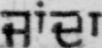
ਜਾਂਦਾ
